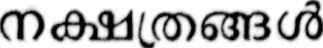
നക്ഷത്രങ്ങള്‍
